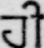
ਹੀ
